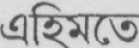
এহিমতে
